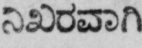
ನಿಖರವಾಗಿ
